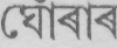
ঘোৰাৰ
